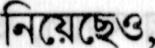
নিয়েছেও,
